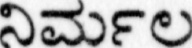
ನಿರ್ಮಲ
